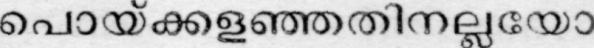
പൊയ്ക്കളഞ്ഞതിനല്ലയോ
